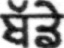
ਬੱਡੇ
